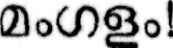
മംഗളം!
